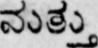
ಮತ್ತು
